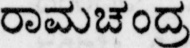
ರಾಮಚಂದ್ರ
